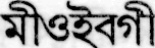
মীওইবগী
